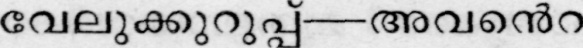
വേലുക്കുറുപ്പ്-അവന്റെ
